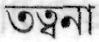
তত্বনা
